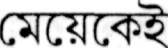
মেয়েকেই
